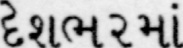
દેશભરમાં
